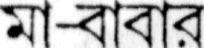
মা-বাবার
